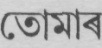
তোমাৰ
